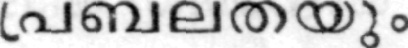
പ്രബലതയും
